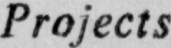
Projects
